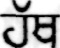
ਹੱਥ
